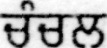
ਚੰਚਲ
